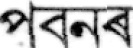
পবনৰ
